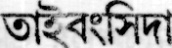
তাইবংসিদা
